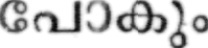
പോകും
